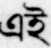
এই
